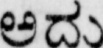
ಅದು
